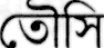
তৌসি
